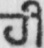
ਹੀ
